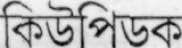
কিউপিডক
